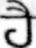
ਹੈ
